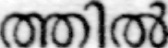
ത്തില്‍
